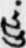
હું
